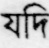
যদি
